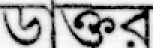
ডাক্তর
